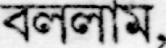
বললাম,
